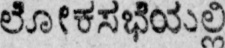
ಲೋಕಸಭೆಯಲ್ಲಿ
